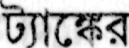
ট্যাঙ্কের
